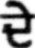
ਦੇ
